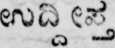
ಉದ್ದೀಪ್ತ
